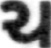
ચ
